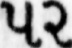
પર
